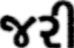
જરી
